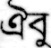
ঐবু
